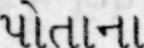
પોતાના
